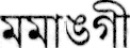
মমাঙগী
